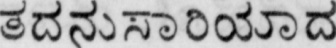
ತದನುಸಾರಿಯಾದ
